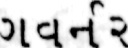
ગવર્નર
